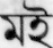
মই
